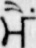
ਮੈਂ
